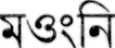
মওংনি
